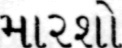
મારશો
